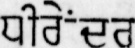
ਧੀਰੇਂਦਰ
